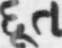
દૂત
